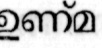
ഉണ്മ
